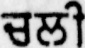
ਚਲੀ
